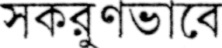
সকরুণভাবে
